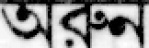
অরুন
